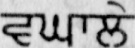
ਵਘਾਲੇ
